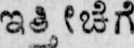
ಇತ್ತೀಚೆಗೆ
